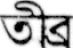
তীব্ৰ
